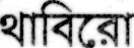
থাবিরো
